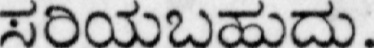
ಸರಿಯಬಹುದು.
